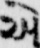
એ
